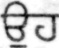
ਉਹ
